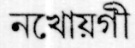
নখোয়গী
